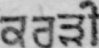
ਕਰੜੀ
